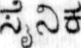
ಸೈನಿಕ
